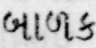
બાળક
